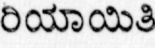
ರಿಯಾಯಿತಿ
